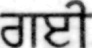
ਗਈ
